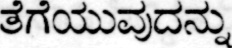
ತೆಗೆಯುವುದನ್ನು
